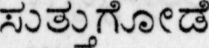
ಸುತ್ತುಗೋಡೆ
